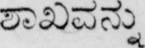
ಶಾಖವನ್ನು
